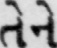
તેને
